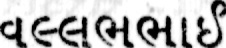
વલ્લભભાઈ
